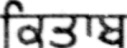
ਕਿਤਾਬ
